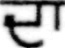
ਦਾ
